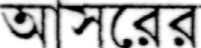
আসরের
